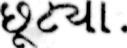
છૂટ્યા.
